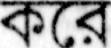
করে
